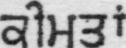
ਕੀਮਤਾਂ
